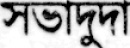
সভাদুদা
